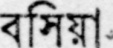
বসিয়া
